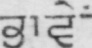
ਭਾਵੇਂ
